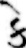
કે
